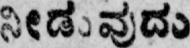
ನೀಡುವುದು
